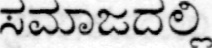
ಸಮಾಜದಲ್ಲಿ
